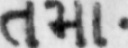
તમા
